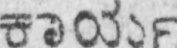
ಕಾರ್ಯ
